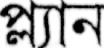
প্ল্যান
